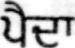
ਪੈਦਾ
